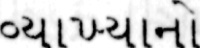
વ્યાખ્યાનો
